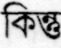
কিন্তু
